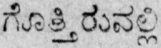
ಗೊತ್ತಿರುವಲ್ಲಿ
